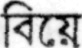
বিয়ে
